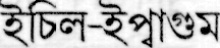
ইচিল-ইপ্বাগুম
